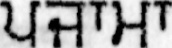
ਪਜਾਮਾ
